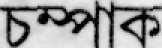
চম্পাক
